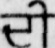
ਦੀ
